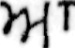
ਆ
